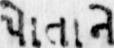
પોતાને
